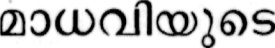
മാധവിയുടെ
